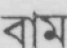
বাম
